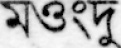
মওংদু
